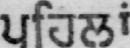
ਪਹਿਲਾਂ
